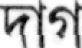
দাগ
